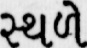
સ્થળે
